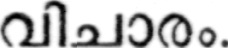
വിചാരം.
